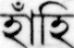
হাঁহি
